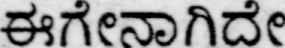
ಈಗೇನಾಗಿದೇ
